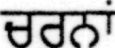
ਚਰਨਾਂ
